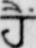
ਹੈਂ
